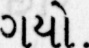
ગયો.
